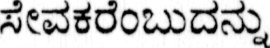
ಸೇವಕರೆಂಬುದನ್ನು
